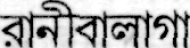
রানীবালাগা
